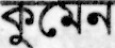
কুমেন
